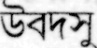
উবদসু
